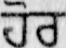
ਹੋਰ
